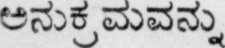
ಅನುಕ್ರಮವನ್ನು
